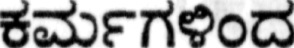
ಕರ್ಮಗಳಿಂದ
